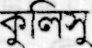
কুলিসু
